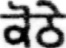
ਕੋਠੇ
